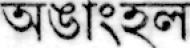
অঙাংহল
